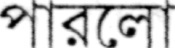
পারলো
